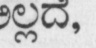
ಅಲ್ಲದೆ,
